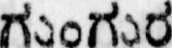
ಗುಂಗುರ
